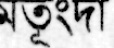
মতূংদা
